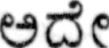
ಅದೇ
